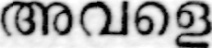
അവളെ
